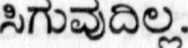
ಸಿಗುವುದಿಲ್ಲ.
